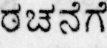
ರಚನೆಗೆ
